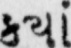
ક્યાં
